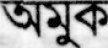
অমুক
